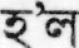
হ'ল
